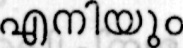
എനിയും
